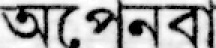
অপেনবা
